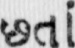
છતાં
